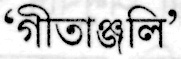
‘গীতাঞ্জলি’
